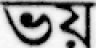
ভয়
